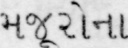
મજૂરોના
